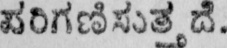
ಪರಿಗಣಿಸುತ್ತದೆ.
